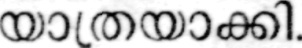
യാത്രയാക്കി.
